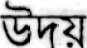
উদয়
